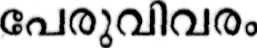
പേരുവിവരം
